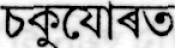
চকুযোৰত
